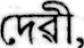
দেৱী,
